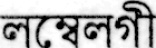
লম্বেলগী
